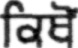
ਕਿਥੋਂ
